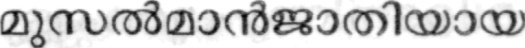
മുസല്‍മാന്‍ജാതിയായ
